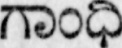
ಗಾಂಧಿ
